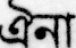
ঐনা
